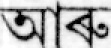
আৰু
